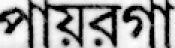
পায়রগা
